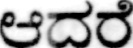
ಆದರೆ
